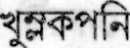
খুম্লকপনি
